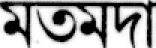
মতমদা
